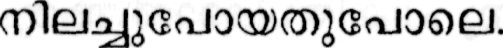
നിലച്ചുപോയതുപോലെ.
